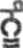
ਨੂੰ
